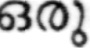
ഒരു
